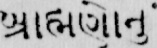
બ્રાહ્મણોનું
